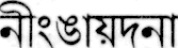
নীংঙায়দনা
